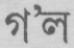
গ'ল
